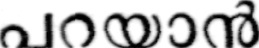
പറയാന്‍
